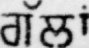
ਗੱਲਾਂ
